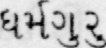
ધર્મગુરુ
